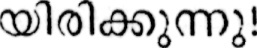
യിരിക്കുന്നു!
